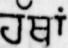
ਹੱਥਾਂ
